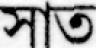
সাত
